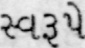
સ્વરૂપે
